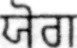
ਯੋਗ
